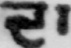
ਦਾ
